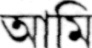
আমি
